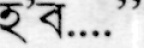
হ'ব...."
